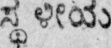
ಸ್ಥಳೀಯ
